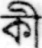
কী
